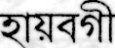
হায়বগী
